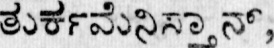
ತುರ್ಕಮೆನಿಸ್ತಾನ್,
